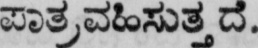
ಪಾತ್ರವಹಿಸುತ್ತದೆ.
